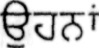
ਉਹਨਾਂ
